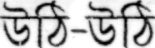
উঠি-উঠি
